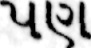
પણ
